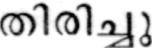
തിരിച്ചു
